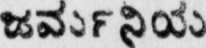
ಜರ್ಮನಿಯ
